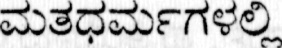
ಮತಧರ್ಮಗಳಲ್ಲಿ
